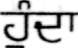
ਹੁੰਦਾ
